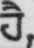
ਹੈ,
